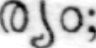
ര്യം;
